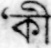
‘কী
